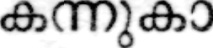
കന്നുകാ
